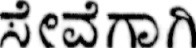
ಸೇವೆಗಾಗಿ
